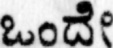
ಒಂದೇ
